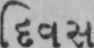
દિવસ
